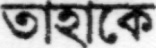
তাহাকে
